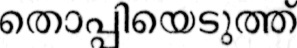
തൊപ്പിയെടുത്ത്
